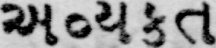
અવ્યક્ત
